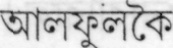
আলফুলকৈ
